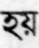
হয়
